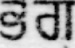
ਭਗ
